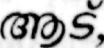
ആട്,
